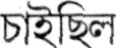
চাইছিল
